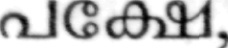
പക്ഷേ,
